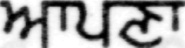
ਆਪਣਾ
